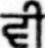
ਵੀ
